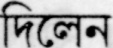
দিলেন
